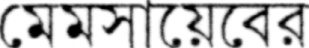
মেমসায়েবের
